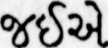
જઈએ
